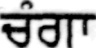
ਚੰਗਾ
